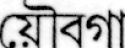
য়ৌবগা
